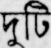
দুটি
